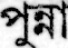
পুন্না
